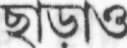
ছাড়াও
